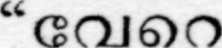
"വേറെ
